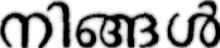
നിങ്ങള്‍
